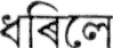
ধৰিলে
